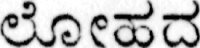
ಲೋಹದ
